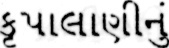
કૃપાલાણીનું
